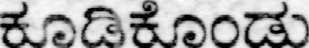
ಕೂಡಿಕೊಂಡು
